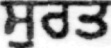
ਸੁਰਤ
